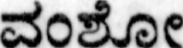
ವಂಶೋ
